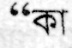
“কা
